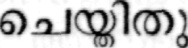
ചെയ്തിതു
